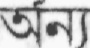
অন্য
